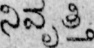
ನಿವೃತ್ತಿ
